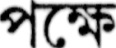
পক্ষে
